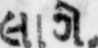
લાગે.
